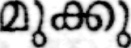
മുക്കു
